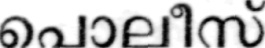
പൊലീസ്
